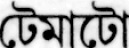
টেমাটো
